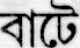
বাটে
